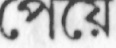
পেয়ে
